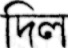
দিল
